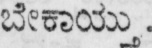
ಬೇಕಾಯ್ತು.
